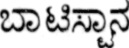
ಬಾಟಿಸ್ಟಾನ
